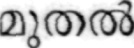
മുതല്‍
